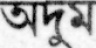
অদুম
